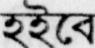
হইবে
